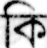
কি
